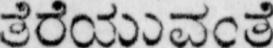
ತೆರೆಯುವಂತೆ
